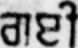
ਗਈ
